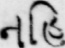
નહિ
